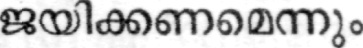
ജയിക്കണമെന്നും
